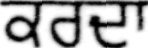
ਕਰਦਾ
